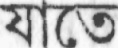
যাতে
